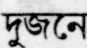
দুজনে
